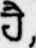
ਹੈ,
